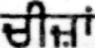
ਚੀਜ਼ਾਂ
